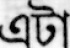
এটা
